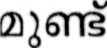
മുണ്ട്
